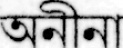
অনীনা
